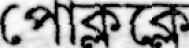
পোক্লক্লে
